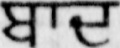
ਬਾਦ
